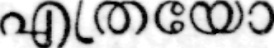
എത്രയോ
